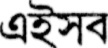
এইসব
